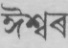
ঈশ্বৰ
